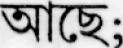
আছে;
